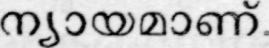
ന്യായമാണ്.
